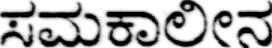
ಸಮಕಾಲೀನ
